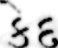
કેદ
